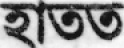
হাতত
